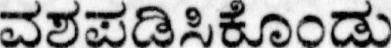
ವಶಪಡಿಸಿಕೊಂಡು
